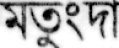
মতুংদা
